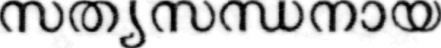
സത്യസന്ധനായ
